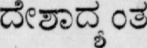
ದೇಶಾದ್ಯಂತ
